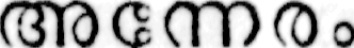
അന്നേരം
